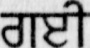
ਗਈ
